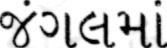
જંગલમાં
